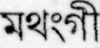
মথংগী
